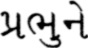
પ્રભુને
